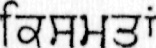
ਕਿਸਮਤਾਂ
